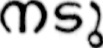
നടു
